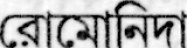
রোমোনিদা
